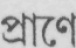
প্ৰাণে
